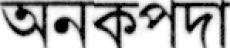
অনকপদা
